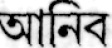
আনিব
